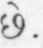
છે.
